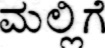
ಮಲ್ಲಿಗೆ
